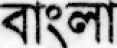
বাংলা
